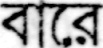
বারে
